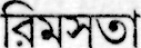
রিমসতা
